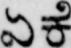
ಏಕೆ
